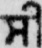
ਸੀ
